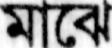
মাঝে
